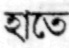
হাতে
